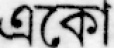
একো
